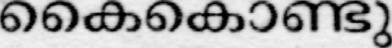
കൈകൊണ്ടു
